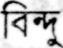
বিন্দু
